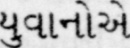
યુવાનોએ
